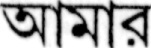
আমার
